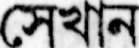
সেখান
